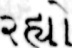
રહ્યો
